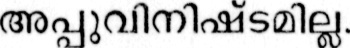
അപ്പുവിനിഷ്ടമില്ല.
